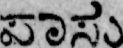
ಪಾಸು
